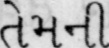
તેમની
